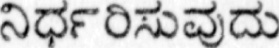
ನಿರ್ಧರಿಸುವುದು
